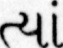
ત્યાં
